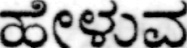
ಹೇಳುವ
